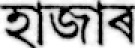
হাজাৰ
